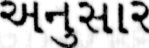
અનુસાર
